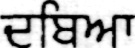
ਦਬਿਆ
